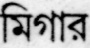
মিগার
